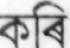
কৰি
